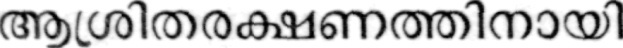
ആശ്രിതരക്ഷണത്തിനായി
